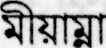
মীয়াম্না
